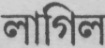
লাগিল
